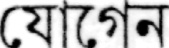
যোগেন
